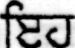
ਇਹ
